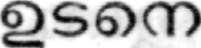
ഉടനെ
